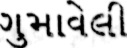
ગુમાવેલી
